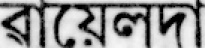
ৱায়েলদা
